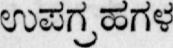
ಉಪಗ್ರಹಗಳ
